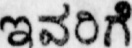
ಇವರಿಗೆ
